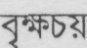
বৃক্ষচয়
